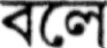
বলে
